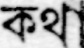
কথা
